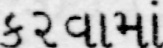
કરવામાં
